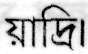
য়াদ্রি।
